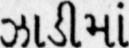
ઝાડીમાં
